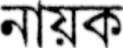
নায়ক
